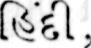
હિંદી,
